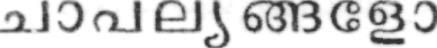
ചാപല്യങ്ങളോ
